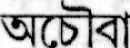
অচৌবা
